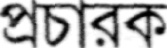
প্রচারক
